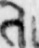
તો
